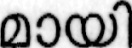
മായി
